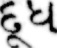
દૂધ
